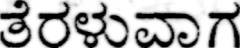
ತೆರಳುವಾಗ
